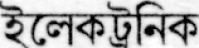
ইলেকট্রনিক
